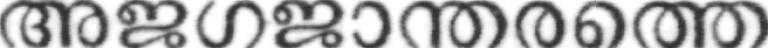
അജഗജാന്തരത്തെ
